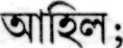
আহিল;
